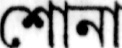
শোনা
